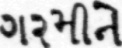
ગરમીને
